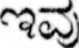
ಇವು
